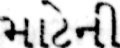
માટેની
